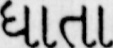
ધાતા
